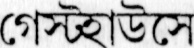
গেস্টহাউসে
